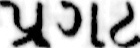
પ્રગટ
